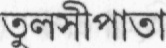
তুলসীপাতা
